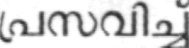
പ്രസവിച്ച്
